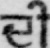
ਦੀ
